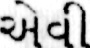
એવી
